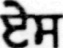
ਏਸ
